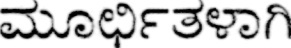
ಮೂರ್ಛಿತಳಾಗಿ
